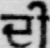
ਦੀ
